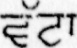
ਵੱਟਾ
